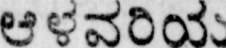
ಆಳವರಿಯ
